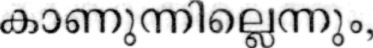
കാണുന്നില്ലെന്നും,
